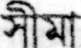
সীমা
